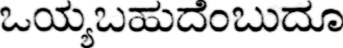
ಒಯ್ಯಬಹುದೆಂಬುದೂ
